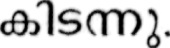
കിടന്നു.
